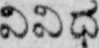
ವಿವಿಧ
